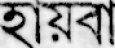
হায়বা
